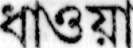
ধাওয়া
